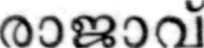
രാജാവ്
